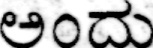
ಅಂದು
